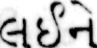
લઈને
